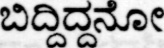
ಬಿದ್ದಿದ್ದನೋ
